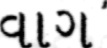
વાગ
